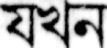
যখন
